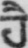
ਹੈ
